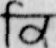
ਕਿ
